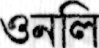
ওনলি
